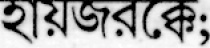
হায়জরক্কে;
